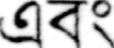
এবং
